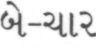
બે-ચાર
